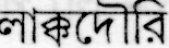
লাক্কদৌরি
